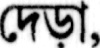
দেড়া,
